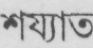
শয্যাত
